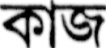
কাজ
